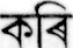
কৰি
